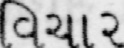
વિચાર
